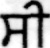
ਸੀ
